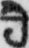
ਹੈ
